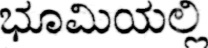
ಭೂಮಿಯಲ್ಲಿ
